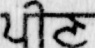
ਪੀਣ
